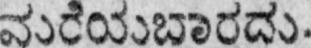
ಮರೆಯಬಾರದು.
